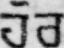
ਹੋਰ
